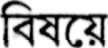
বিষয়ে
